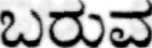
ಬರುವ
